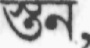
স্তন,
